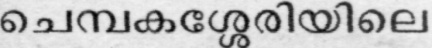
ചെമ്പകശ്ശേരിയിലെ
